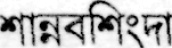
শান্নবশিংদা
